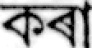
কৰা
